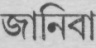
জানিবা
